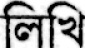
লিখি
